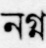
নগ্ন
